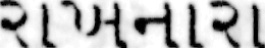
રાખનારા
